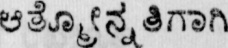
ಆತ್ಮೋನ್ನತಿಗಾಗಿ
